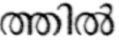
ത്തില്‍
